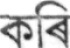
কৰি
